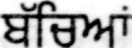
ਬੱਚਿਆਂ
